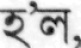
হ'ল,
